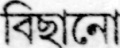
বিছানো
